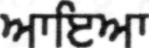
ਆਇਆ
